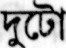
দুটো
